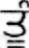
ਤੂੰ
